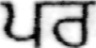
ਪਰ
